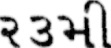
૨૩મી
